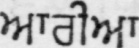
ਆਰੀਆ
